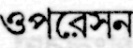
ওপরেসনৱ
